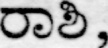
ರಾಶಿ,
